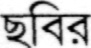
ছবির
